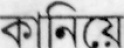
কানিয়ে
